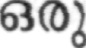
ഒരു
